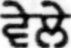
ਵੇਲੇ
